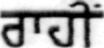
ਰਾਹੀਂ
